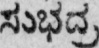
ಸುಭದ್ರ
